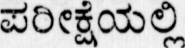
ಪರೀಕ್ಷೆಯಲ್ಲಿ
